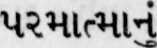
પરમાત્માનું
